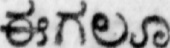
ಈಗಲೂ
